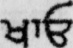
ਖਾਓ
